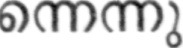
ന്നെന്നു
